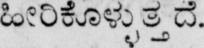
ಹೀರಿಕೊಳ್ಳುತ್ತದೆ.
